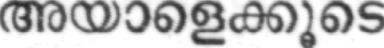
അയാളെക്കൂടെ
